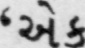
'એક
